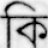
কি
